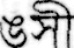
ঙসী
